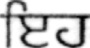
ਇਹ
